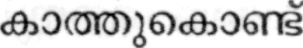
കാത്തുകൊണ്ട്
